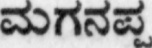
ಮಗನಪ್ಪ
